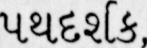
પથદર્શક,
